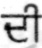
ਦੀ
